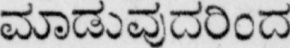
ಮಾಡುವುದರಿಂದ
